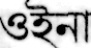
ওইনা
